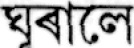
ঘূৰালে
